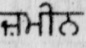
ਜ਼ਮੀਨ
